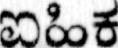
ಐಹಿಕ
